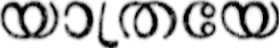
യാത്രയേ
